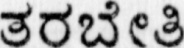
ತರಬೇತಿ
